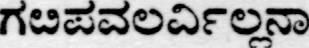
ಗೞಪವಲರ್ವಿಲ್ಲನಾ
